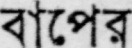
বাপের
